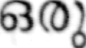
ഒരു
